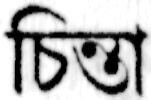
চিন্তা
